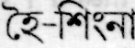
হৈ-শিংনা
